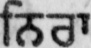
ਨਿਰਾ
